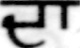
ਦਾ
